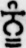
ਨੂੰ
